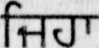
ਜਿਹਾ
